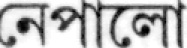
নেপালো
